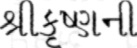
શ્રીકૃષ્ણની
